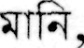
মানি,
